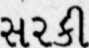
સરકી
